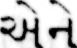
એને
